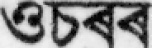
ওচৰৰ
